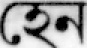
হেন
